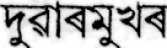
দুৱাৰমুখৰ
